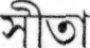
সীতা
